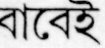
বাবেই
